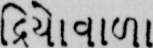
દ્રિયોવાળા
